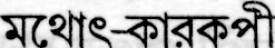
মথোৎ-কারকপী
